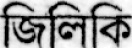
জিলিকি
